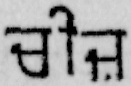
ਚੀਜ਼
